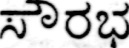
ಸೌರಭ
